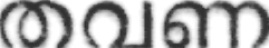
തവണ
